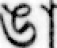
ঙা
